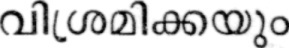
വിശ്രമിക്കയും
